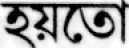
হয়তো
